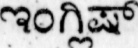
ಇಂಗ್ಲಿಷ್
